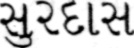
સુરદાસ
